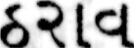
ઠરાવ
